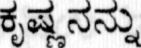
ಕೃಷ್ಣನನ್ನು
